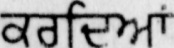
ਕਰਦਿਆਂ
